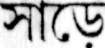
সাড়ে
